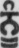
ਨੂੰ
